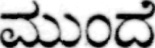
ಮುಂದೆ
